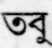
তবু
